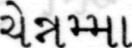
ચેન્નમ્મા
